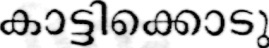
കാട്ടിക്കൊടു
